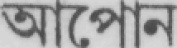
আপোন
